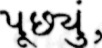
પૂછ્યું,
